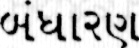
બંધારણ
